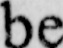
be
